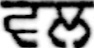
ਵਲ
